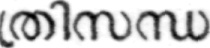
ത്രിസന്ധ
